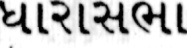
ધારાસભા
